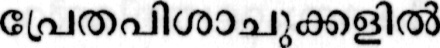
പ്രേതപിശാചുക്കളില്‍
